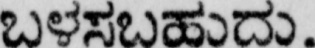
ಬಳಸಬಹುದು.
